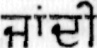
ਜਾਂਦੀ
